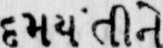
દમયંતીને
